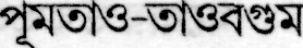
পুমতাও-তাওবগুম
